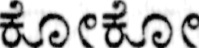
ಕೋಕೋ
